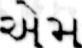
એમ
